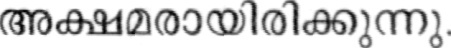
അക്ഷമരായിരിക്കുന്നു.
